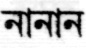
নানান
